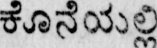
ಕೊನೆಯಲ್ಲಿ
